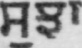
ਸੁਝਾ
